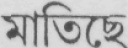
মাতিছে
